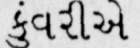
કુંવરીએ
